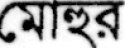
মোহুর
